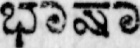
ಭಾಷಾ
